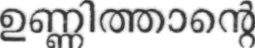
ഉണ്ണിത്താന്റെ
